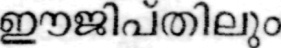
ഈജിപ്തിലും
